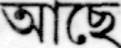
আছে
